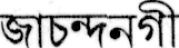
জাচন্দুনগী
